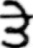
ਤੇ
